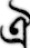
ঐ
